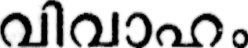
വിവാഹം
